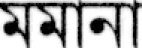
মমানা
